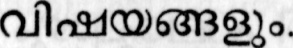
വിഷയങ്ങളും.
